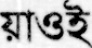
য়াওই
